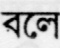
বলে
